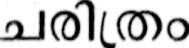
ചരിത്രം
